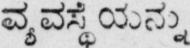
ವ್ಯವಸ್ಥೆಯನ್ನು
